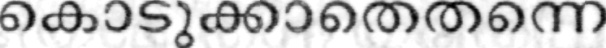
കൊടുക്കാതെതന്നെ
